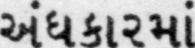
અંધકારમાં
